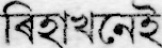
ৰিহাখনেই
